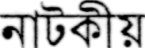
নাটকীয়
